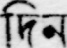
দিন
